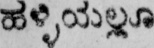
ಹಳ್ಳಿಯಲ್ಲೂ
